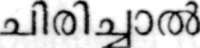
ചിരിച്ചാല്‍
